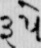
રૂપે
